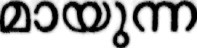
മായുന്ന
